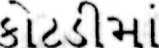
કોટડીમાં
